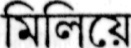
মিলিয়ে
